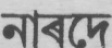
নাৰদে
